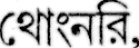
থোংনরি,
